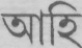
আহি
